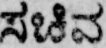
ಸಚಿವ
